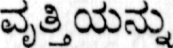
ವೃತ್ತಿಯನ್ನು
